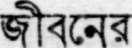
জীবনের
